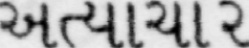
અત્યાચાર
